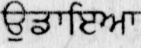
ਉਡਾਇਆ
